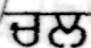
ਚਲ
